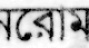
রোম
